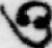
ও
